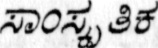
ಸಾಂಸ್ಕೃತಿಕ
